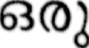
ഒരു
